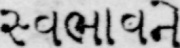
સ્વભાવને
